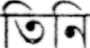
তিনি
